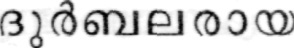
ദുര്‍ബലരായ
